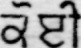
ਕੋਈ
